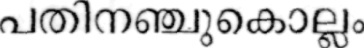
പതിനഞ്ചുകൊല്ലം
